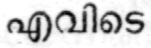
എവിടെ
